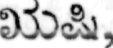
ಋಷಿ,
